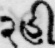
રહી
